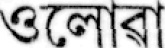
ওলোৱা
